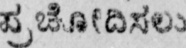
ಪ್ರಚೋದಿಸಲು
